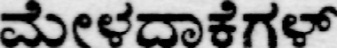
ಮೇಳದಾಕೆಗಳ್
